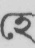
হে
